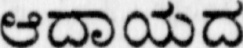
ಆದಾಯದ
